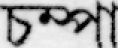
চম্পা
